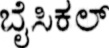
ಬೈಸಿಕಲ್
